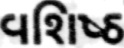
વશિષ્ઠ
